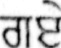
ਗਏ
